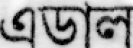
এডাল
